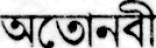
অতোনবী
